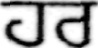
ਹਰ
